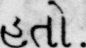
હતો.
